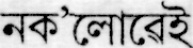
নক'লোৱেই
